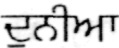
ਦੁਨੀਆ
